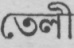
তেলী
